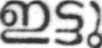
ഇട്ടു
